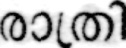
രാത്രി
